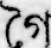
গৈ
